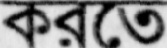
করতে
